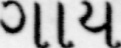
ગાય
